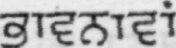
ਭਾਵਨਾਵਾਂ
